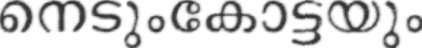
നെടുംകോട്ടയും
